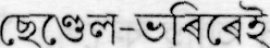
ছেণ্ডেল-ভৰিৰেই
